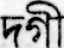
দগী
